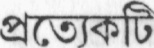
প্রত্যেকটি
